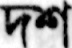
দশ
